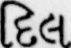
દિલ
